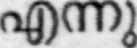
എന്നു
